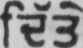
ਦਿੱਤੇ
